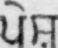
ਪੇਸ਼
